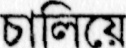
চালিয়ে
